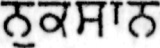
ਨੁਕਸਾਨ
